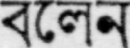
বলেন
